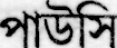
পাউসি
